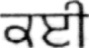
ਕਈ
